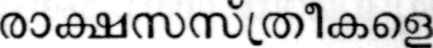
രാക്ഷസസ്ത്രീകളെ
